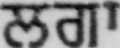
ਲਗਾ
